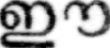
ഈ
